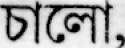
চালো,
